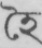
হৈ
